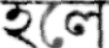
হলে
